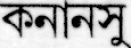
কনানসু
